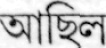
আছিল
